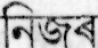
নিজৰ
